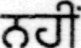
ਨਹੀਂ
